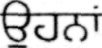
ਉਹਨਾਂ
